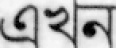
এখন
